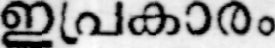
ഇപ്രകാരം
